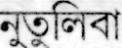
নুতুলিবা
